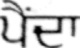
ਪੈਂਦਾ
